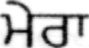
ਮੇਰਾ
